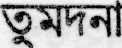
তুমদনা
